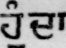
ਹੁੰਦਾ
